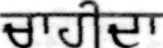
ਚਾਹੀਦਾ
